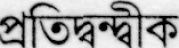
প্রতিদ্বন্দ্বীক
